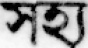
সহ্য
